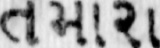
તમારા
